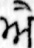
ਐ
